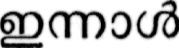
ഇന്നാള്‍
